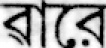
ৱারে
